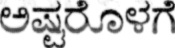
ಅಷ್ಟರೊಳಗೆ
